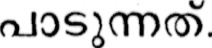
പാടുന്നത്.
